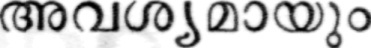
അവശ്യമായും
